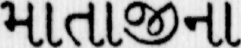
માતાજીના
